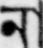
না
